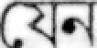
যেন
